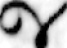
જ
